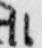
તો
